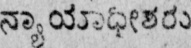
ನ್ಯಾಯಾಧೀಶರು
